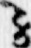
કે
